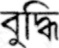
বুদ্ধি
